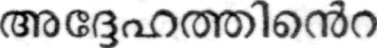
അദ്ദേഹത്തിന്റെ
